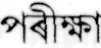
পৰীক্ষা
